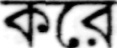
করে
